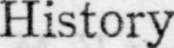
History
